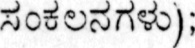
ಸಂಕಲನಗಳು);
